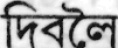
দিবলৈ
